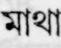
মাথা
